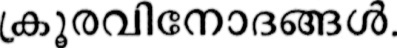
ക്രൂരവിനോദങ്ങള്‍.
